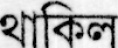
থাকিল
